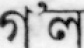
গ'ল
